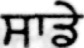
ਸਾਡੇ
